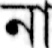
না
